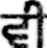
ਵੀ
